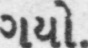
ગયો.
